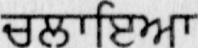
ਚਲਾਇਆ
